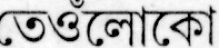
তেওঁলোকো
